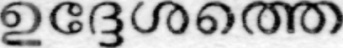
ഉദ്ദേശത്തെ
